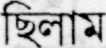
ছিলাম
